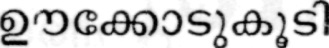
ഊക്കോടുകൂടി
